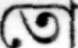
তো
